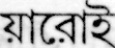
য়ারোই
